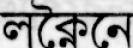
লক্নৈনে
